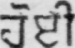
ਹੋਈ
